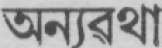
অন্যৱথা
